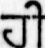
ਹੀ
